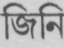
জিনি
